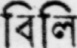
বিলি
